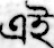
এই
